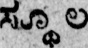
ಸ್ಥೂಲ
